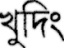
খুদিং
